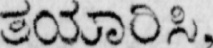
ತಯಾರಿಸಿ,
